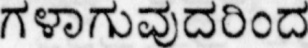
ಗಳಾಗುವುದರಿಂದ
